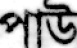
পাউ
